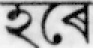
হৰে
